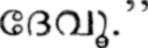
ദേവൂ."
